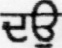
ਦਉ
